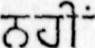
ਨਹੀਂ
